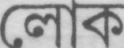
লোক
